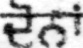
ਦੋਨਾਂ
